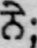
ਨੇ;
